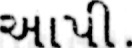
આપી.
